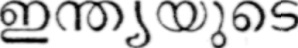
ഇന്ത്യയുടെ
